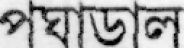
পঘাডাল
